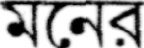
মনের
